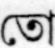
তো
